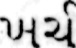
ખર્ચ
